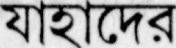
যাহাদের
